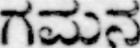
ಗಮನ
